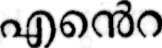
എന്റെ
